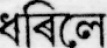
ধৰিলে
